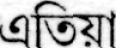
এতিয়া
